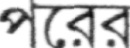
পরের
